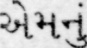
એમનું
